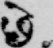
છે.
